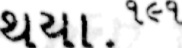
થયા.૧૯૧
